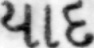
યાદ
